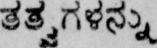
ತತ್ವಗಳನ್ನು
